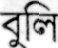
বুলি
